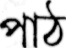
পাঠ
